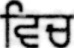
ਵਿਚ
